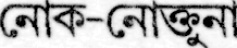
নোক-নোক্তুনা
